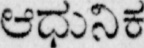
ಆಧುನಿಕ
